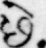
છે.
